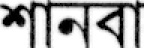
শানবা
